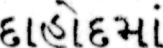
દાહોદમાં
